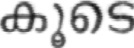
കൂടെ
